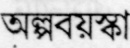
অল্পবয়স্কা
